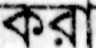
করা
